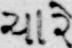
ચારે
